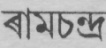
ৰামচন্দ্ৰ
